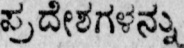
ಪ್ರದೇಶಗಳನ್ನು
